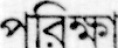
পরিক্ষা
